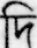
দি
